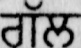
ਗੱਲ
